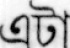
এটা
